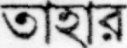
তাহার
